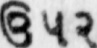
ઉપર
